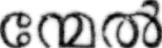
ന്മേല്‍
